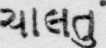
ચાલતું
